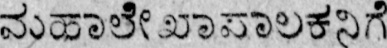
ಮಹಾಲೇಖಾಪಾಲಕನಿಗೆ
